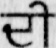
ਦੀ
